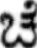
ಚೆ
